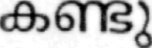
കണ്ടു
